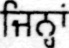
ਜਿਨ੍ਹਾਂ
